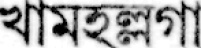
খামহল্লগা
